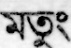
মতুং
